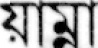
য়াম্না
